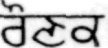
ਰੌਣਕ
